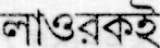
লাওরকই
